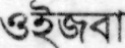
ওইজবা
